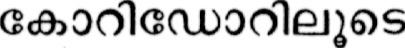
കോറിഡോറിലൂടെ
